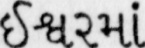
ઈશ્વરમાં
